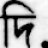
দি.
